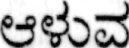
ಆಳುವ
